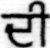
ਦੀ
